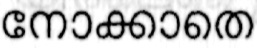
നോക്കാതെ
